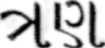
ત્રણ
